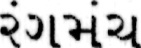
રંગમંચ
